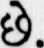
છે.
